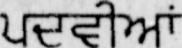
ਪਦਵੀਆਂ
